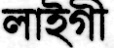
লাইগী
